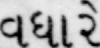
વધારે
